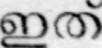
ഇത്
